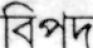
বিপদ
